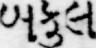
બકુલ
